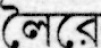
লৈরে
